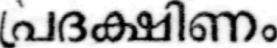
പ്രദക്ഷിണം
